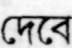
দেবে
